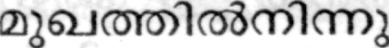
മുഖത്തില്‍നിന്നു
